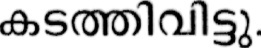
കടത്തിവിട്ടു.
